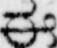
ಈ
